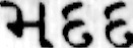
મદદ
